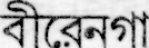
বীরেনগা
